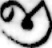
જી
